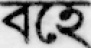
বহে
